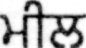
ਮੀਲ
